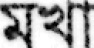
মখা
